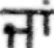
ਜਾਂ
